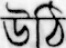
উঠি
